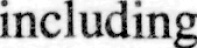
including
